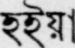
হইয়া
